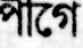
পীগে
